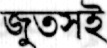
জুতসই
